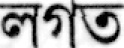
লগত
